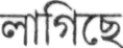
লাগিছে
